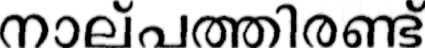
നാല്പത്തിരണ്ട്
